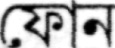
ফোন
